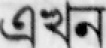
এখন
